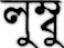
লুম্বু
